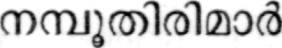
നമ്പൂതിരിമാര്‍
